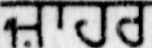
ਜ਼ਾਹਰ
